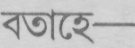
বতাহে-
